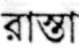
রাস্তা
